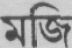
মজি
